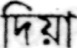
দিয়া
